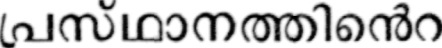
പ്രസ്ഥാനത്തിന്റെ
